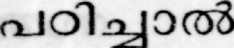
പഠിച്ചാല്‍
